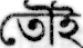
তৌই
